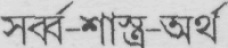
সৰ্ব্ব-শাস্ত্ৰ-অৰ্থ
